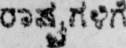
ರಾಷ್ಟ್ರಗಳಿಗೆ
